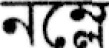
নম্লে
